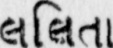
લલિતા
